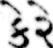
કેરે
